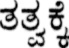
ತತ್ವಕ್ಕೆ
